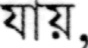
যায়,
